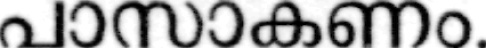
പാസാകണം.
